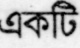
একটি
